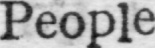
People
